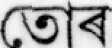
তোৰ
